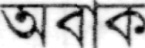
অবাক
